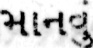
માનવું
